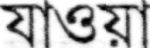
যাওয়া
